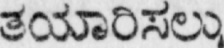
ತಯಾರಿಸಲು
